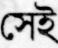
সেই
